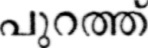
പുറത്ത്
